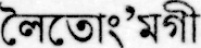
লৈতোং’মগী
